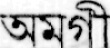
অমগী
